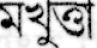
মখুত্তা
